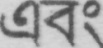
এবং
